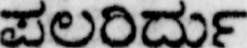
ಪಲರಿರ್ದು
